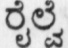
ರೈಲ್ವೆ
